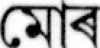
মোৰ
